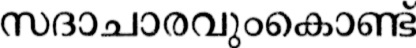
സദാചാരവുംകൊണ്ട്
